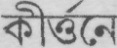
কীৰ্ত্তনে
